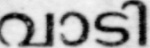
വാടി
